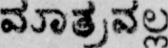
ಮಾತ್ರವಲ್ಲ
